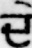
ਦੇ
